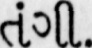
તંગી.
